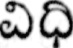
ವಿಧಿ
